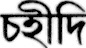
চহীদি
